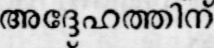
അദ്ദേഹത്തിന്
